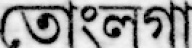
তোংলগা
